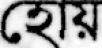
হোয়
